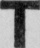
T
